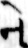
ને
